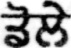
ਡੋਲੇ
